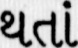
થતાં
